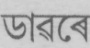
ডাৱৰে
